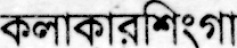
কলাকারশিংগা
